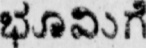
ಭೂಮಿಗೆ
